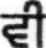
ਵੀ
